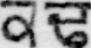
ਕਢ
